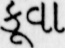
કૂવા
